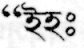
“ইহঃ
